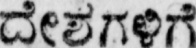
ದೇಶಗಳಿಗೆ
